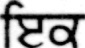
ਇਕ
